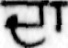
ਦਾ
